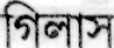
গিলাস
